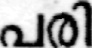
പരി
